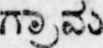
ಗ್ರಾಮ
